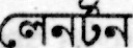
লেনর্টন
